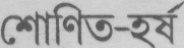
শোণিত-হৰ্ষ
